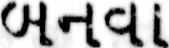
બનવા
